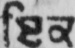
ਇਕ
